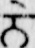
ਨੇ
